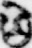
છે
